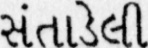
સંતાડેલી
